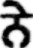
ਨੇ
